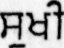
ਸੁਖੀ
